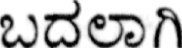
ಬದಲಾಗಿ
